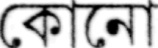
কোনো
